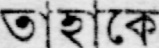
তাহাকে
